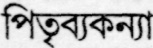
পিতৃব্যকন্যা
